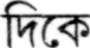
দিকে
